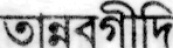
তান্নবগীদি
